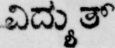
ವಿದ್ಯುತ್
